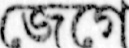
জেগে
